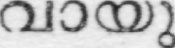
വായു
